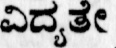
ವಿದ್ಯತೇ
